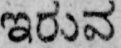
ಇರುವ
